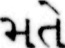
મતે
